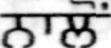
ਨਾਲੋਂ
